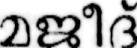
മജീദ്
